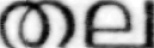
തല
